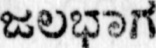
ಜಲಭಾಗ
